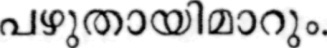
പഴുതായിമാറും.
